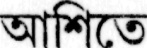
আশিতে
